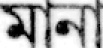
মানা
